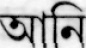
আনি
